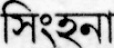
সিংহনা
